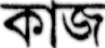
কাজ
